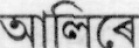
আলিৰে
